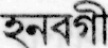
হনবগী
